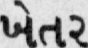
ખેતર
